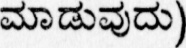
ಮಾಡುವುದು)
